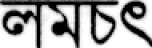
লমচৎ
